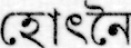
হোৎনৈ
